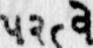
પરત્વે
